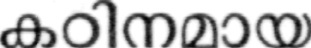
കഠിനമായ
